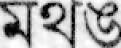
মথঙ
